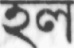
হল
